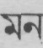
মন
